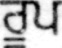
ਰੂਪ
